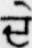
ਦੇ
